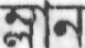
ম্লান
